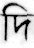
দি
